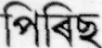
পিৰিছ
